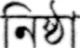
নিষ্ঠা
